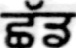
ਛੱਡ
